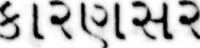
કારણસર
